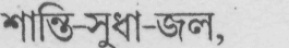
শান্তি-সুধা-জল,
